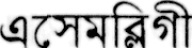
এসেমব্লিগী
